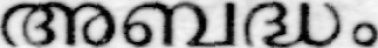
അബദ്ധം
